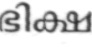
ഭിക്ഷ
